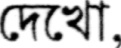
দেখো,
